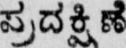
ಪ್ರದಕ್ಷಿಣೆ
